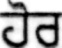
ਹੋਰ
